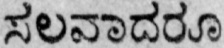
ಸಲವಾದರೂ
